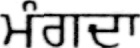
ਮੰਗਦਾ
